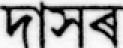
দাসৰ
